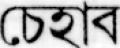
চেহাব
